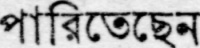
পারিতেছেন
